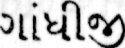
ગાંધીજી
